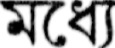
মধ্যে
